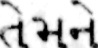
તેમને
